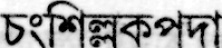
চংশিল্লকপদা
